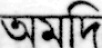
অমদি
